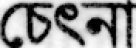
চেৎনা
